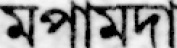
মপামদা
